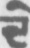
ਦੇ
